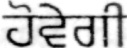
ਹੋਵੇਗੀ
